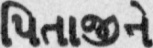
પિતાજીને
